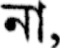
না,
